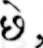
છે,
